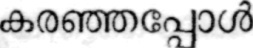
കരഞ്ഞപ്പോള്‍
